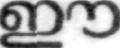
ഈ
